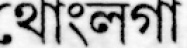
থোংলগা
